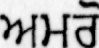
ਅਮਰੋ
